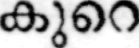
കുറെ
